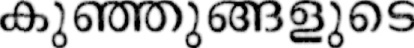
കുഞ്ഞുങ്ങളുടെ
